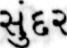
સુંદર
